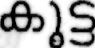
കൂട്ട
